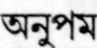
অনুপম
